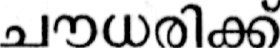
ചൌധരിക്ക്
